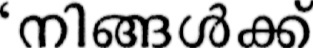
‘നിങ്ങള്‍ക്ക്
